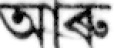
আৰু
